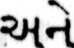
અને
